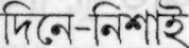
দিনে-নিশাই
